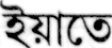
ইয়াতে
